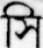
সি
